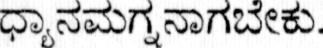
ಧ್ಯಾನಮಗ್ನನಾಗಬೇಕು.
